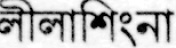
লীলাশিংনা
